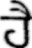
ਹੈ
